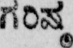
ಗರಿಷ್ಠ
